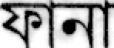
ফানা
